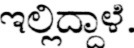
ಇಲ್ಲಿದ್ದಾಳೆ.
